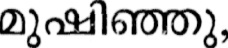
മുഷിഞ്ഞു,
